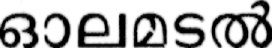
ഓലമടല്‍
